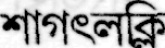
শাগৎলক্লি
